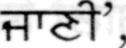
ਜਾਣੀ',
